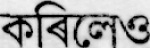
কৰিলেও
